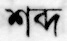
শব্দ
